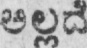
ಅಲ್ಲದೆ
